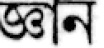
জ্ঞান
